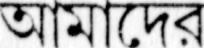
আমাদের
